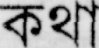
কথা
